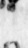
જ
